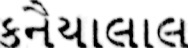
કનૈયાલાલ
